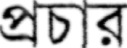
প্রচার
